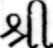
શ્રી
